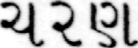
ચરણ
